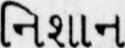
નિશાન
